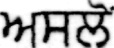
ਅਸਲੋਂ
